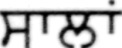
ਸਾਲਾਂ
